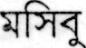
মসিবু
